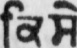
ਕਿਸੇ
